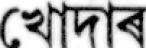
খোদাৰ
